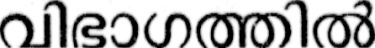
വിഭാഗത്തില്‍
